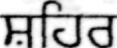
ਸ਼ਹਿਰ
